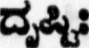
ದೃಷ್ಟಿಃ
